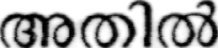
അതില്‍
